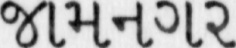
જામનગર
